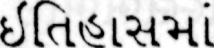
ઇતિહાસમાં
